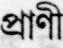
প্রাণী
